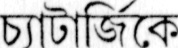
চ্যাটার্জিকে
